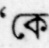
‘কে
